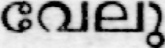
വേലു
